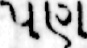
પણ
